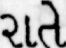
રાતે
